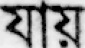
যায়
